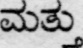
ಮತ್ತು
